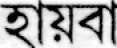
হায়বা
